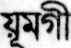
য়ূমগী
